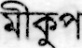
মীকুপ
